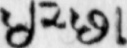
ઈચ્છા
